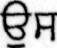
ਉਸ
